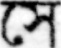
সে
